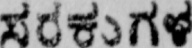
ಸರಕುಗಳ
